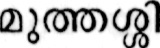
മുത്തശ്ശി
